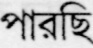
পারছি
